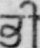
ਭੀ
